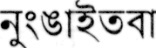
নুংঙাইতবা
